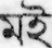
মই
